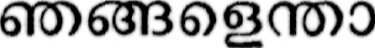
ഞങ്ങളെന്താ
